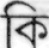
কি
